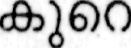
കുറെ
